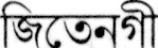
জিতেনগী
